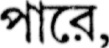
পারে,
